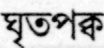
ঘৃতপক্ক
